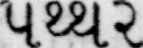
પથ્થર
